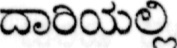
ದಾರಿಯಲ್ಲಿ
